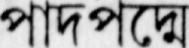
পাদপদ্মে
